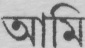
আমি
